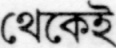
থেকেই
